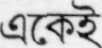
একেই
